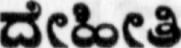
ದೇಹೀತಿ
